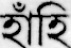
হাঁহি
